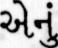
એનું
